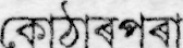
কোঠাৰপৰা
